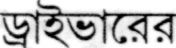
ড্রাইভারের
